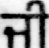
ਜੀ
